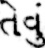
તેવું
